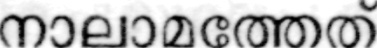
നാലാമത്തേത്
